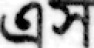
এস
